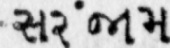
સરંજામ
